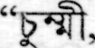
“চুম্মী,
